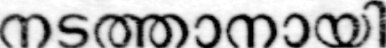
നടത്താനായി
